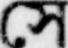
সে
